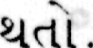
થતો.
